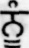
ਨੂੰ
